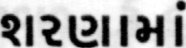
શરણામાં
